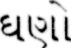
ઘણો
